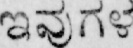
ಇವುಗಳ
